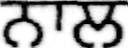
ਨਾਲ
